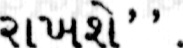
રાખશે".
